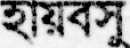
হায়বসু
